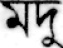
মদু
